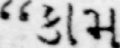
"કામ
